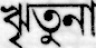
ঋৃতুনা
